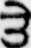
ਤੇ
